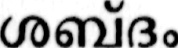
ശബ്ദം
